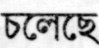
চলেছে
